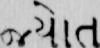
જ્યોત
